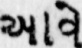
આવે
